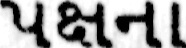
પક્ષના
